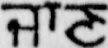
ਜਾਣ
